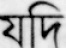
যদি
